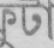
ফুটা
